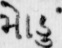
મોડું
